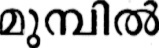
മുമ്പില്‍
